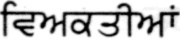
ਵਿਅਕਤੀਆਂ
